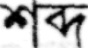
শব্দ
